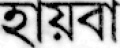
হায়বা
